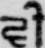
ਵੀ
